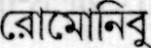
রোমোনিবু
